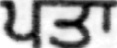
ਪਤਾ
